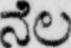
ನೆಲ
